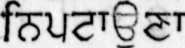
ਨਿਪਟਾਉਣਾ
